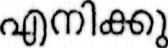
എനിക്കു
